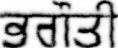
ਭਗੌਤੀ
